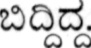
ಬಿದ್ದಿದ್ದ.
